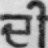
ਦੀ
